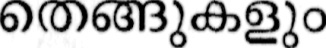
തെങ്ങുകളും
